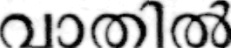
വാതില്‍
